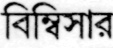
বিম্বিসার
